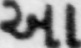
આ
